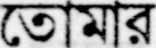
তোমার
